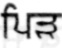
ਪਿੜ
